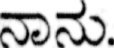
ನಾನು.
